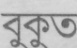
বুকুত
